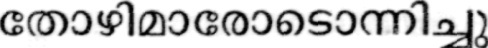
തോഴിമാരോടൊന്നിച്ചു
